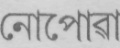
নোপোৱা
